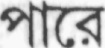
পারে
